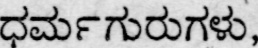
ಧರ್ಮಗುರುಗಳು,
